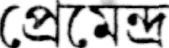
প্রেমেন্দ্র
